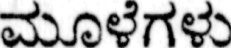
ಮೂಳೆಗಳು
